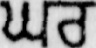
ਘਰ
